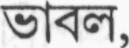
ভাবল,
